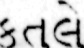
કતલે
